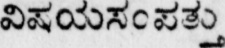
ವಿಷಯಸಂಪತ್ತು
